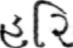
હરિ
